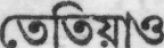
তেতিয়াও
